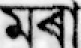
মৰা
